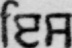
ਇਸ
